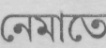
নেমাতে
